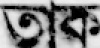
তাক
